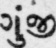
ગુંજી
